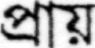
প্রায়
